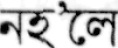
নহ'লে
